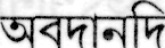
অবদানদি
